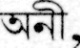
অনী,
